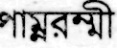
পাম্নরম্মী
